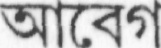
আবেগ
